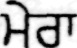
ਮੇਰਾ
